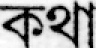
কথা
